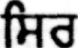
ਸਿਰ
